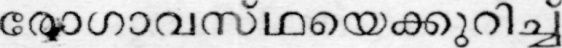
രോഗാവസ്ഥയെക്കുറിച്ച്
